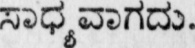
ಸಾಧ್ಯವಾಗದು.
